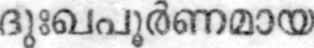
ദുഃഖപൂര്‍ണമായ
